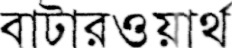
বাটারওয়ার্থ
